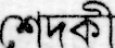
শেদকী
